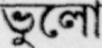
ভুলো
